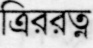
ত্রিররত্ন
